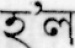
হ'ল
